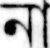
না
